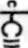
ਨੂੰ
